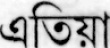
এতিয়া
